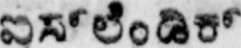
ಐಸ್ಲೆಂಡಿಕ್
